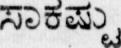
ಸಾಕಷ್ಟು
